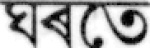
ঘৰতে
